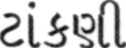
ટાંકણી
